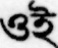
ওই
